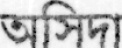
অসিদা
